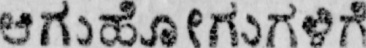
ಆಗುಹೋಗುಗಳಿಗೆ
